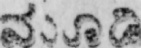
ಮೂಡಿ
